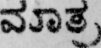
ಮಾತ್ರ
